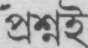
প্রশ্নই
